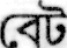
বেট
